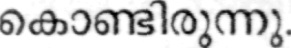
കൊണ്ടിരുന്നു.
